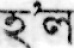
হ'ল
